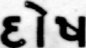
દોષ
